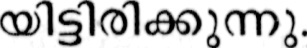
യിട്ടിരിക്കുന്നു.
